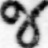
જ
